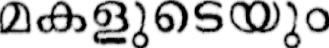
മകളുടെയും
